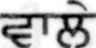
ਵਾਲੇ
